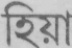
হিয়া
